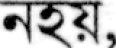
নহয়,
